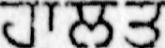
ਹਾਲਤ
